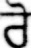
ਰੋ
